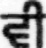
ਵੀ
